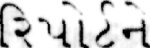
રિપોર્ટને
